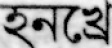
হনখ্রে
